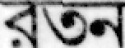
রতন
